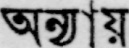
অন্যায়
